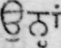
ਉਨ੍ਹਾਂ
